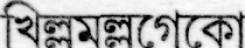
খিল্লমল্লগেকো
